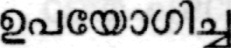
ഉപയോഗിച്ച
